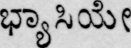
ಭ್ಯಾಸಿಯೇ
